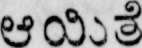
ಆಯಿತೆ
